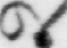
જ
